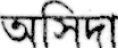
অসিদা
